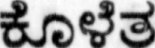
ಕೊಳೆತ
